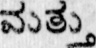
ಮತ್ತು
